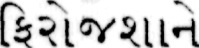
ફિરોજશાને
